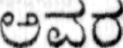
ಅವರ
